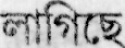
লাগিছে
